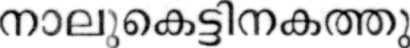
നാലുകെട്ടിനകത്തു
